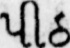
પીઠ
